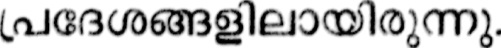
പ്രദേശങ്ങളിലായിരുന്നു.
